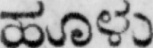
ಹೂಳು
